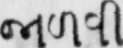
જાળવી
